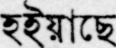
হইয়াছে
